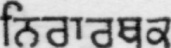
ਨਿਰਾਰਥਕ
